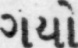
ગયો
